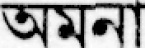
অমনা
